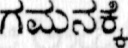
ಗಮನಕ್ಕೆ
